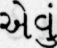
એવું
